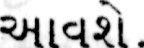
આવશે.
